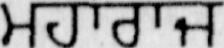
ਮਹਾਰਾਜ
